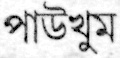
পাউখুম
